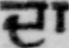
ਦਾ
